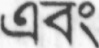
এবং
